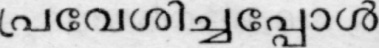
പ്രവേശിച്ചപ്പോള്‍
